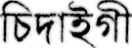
চিদাইগী
